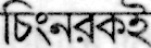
চিংনরকই
